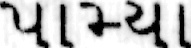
પામ્યા
